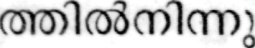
ത്തില്‍നിന്നു
